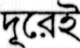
দূরেই
